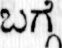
ಬಗ್ಗೆ
